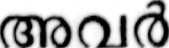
അവര്‍
